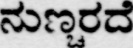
ನುಣ್ಚರದೆ
